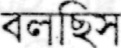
বলছিস
